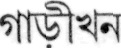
গাড়ীখন
